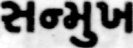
સન્મુખ
